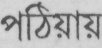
পঠিয়ায়
